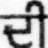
ਦੀ
